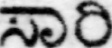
ಸಾರಿ
